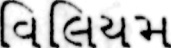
વિલિયમ
